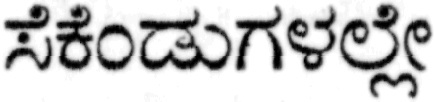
ಸೆಕೆಂಡುಗಳಲ್ಲೇ
